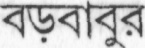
বড়বাবুর
